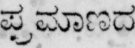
ಪ್ರಮಾಣದ
